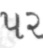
પર
